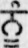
ਨੂੰ
